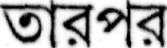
তারপর
